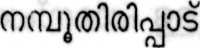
നമ്പൂതിരിപ്പാട്
